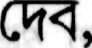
দেব,
